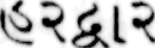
હરદ્વાર
